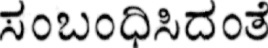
ಸಂಬಂಧಿಸಿದಂತೆ
